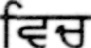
ਵਿਚ
